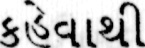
કહેવાથી
